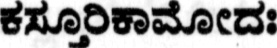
ಕಸ್ತೂರಿಕಾಮೋದಃ
